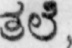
ತಲೆ,
